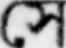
সে
